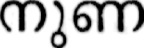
നുണ
